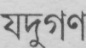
যদুগণ
